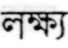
লক্ষ্য
